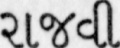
રાજવી
